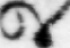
જ
